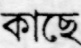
কাছে
